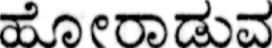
ಹೋರಾಡುವ
